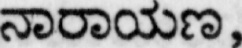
ನಾರಾಯಣ,
